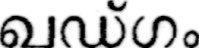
ഖഡ്ഗം
